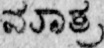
ಮಾತ್ರ
